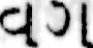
વગ
